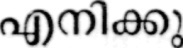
എനിക്കു
